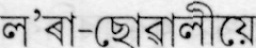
ল'ৰা-ছোৱালীয়ে
